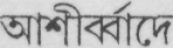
আশীৰ্ব্বাদে
